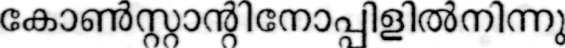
കോണ്‍സ്റ്റാൻ്റിനോപ്പിളില്‍നിന്നു
